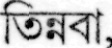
তিন্নবা,
